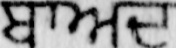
ਬਾਅਦ
